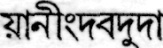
য়ানীংদবদুদা
